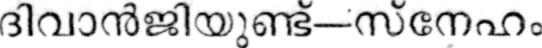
ദിവാന്‍ജിയുണ്ട്-സ്നേഹം
